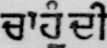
ਚਾਹੁੰਦੀ
